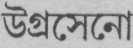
উগ্ৰসেনো
